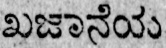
ಖಜಾನೆಯ
